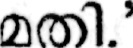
മതി.’
